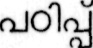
പഠിപ്പ്
